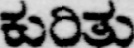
ಕುರಿತು
